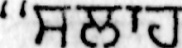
''ਸਲਾਹ
